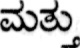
ಮತ್ತು
